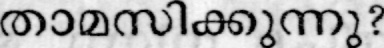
താമസിക്കുന്നു?
